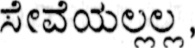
ಸೇವೆಯಲ್ಲಲ್ಲ,
